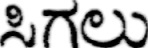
ಸಿಗಲು
